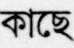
কাছে
